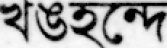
খঙহন্দে
